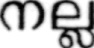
നല്ല
